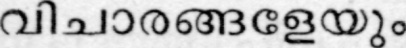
വിചാരങ്ങളേയും
